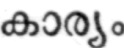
കാര്യം
